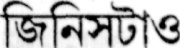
জিনিসটাও
